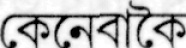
কেনেবাকৈ
